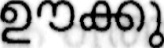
ഊക്കു
